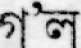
গ'ল
